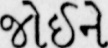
જોઈને
